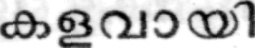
കളവായി
